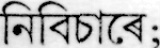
নিবিচাৰে;
